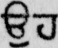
ਉਹ
